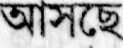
আসছে
